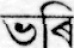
ভৰি
